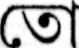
তো
